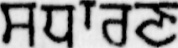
ਸਧਾਰਣ
